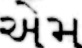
એમ
